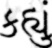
કહ્યું
